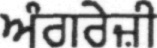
ਅੰਗਰੇਜ਼ੀ
